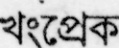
খংপ্রেক
